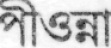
পীওন্না
